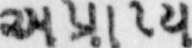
અપ્રાપ્ય
